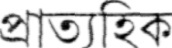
প্রাত্যহিক
